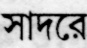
সাদরে
